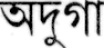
অদুগা
